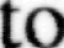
to
